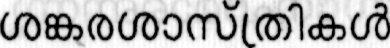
ശങ്കരശാസ്ത്രികള്‍
